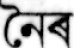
নৈৰ
